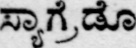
ಸ್ಯಾಗ್ರೆಡೊ
